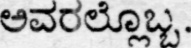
ಅವರಲ್ಲೊಬ್ಬ.
